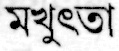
মখুৎতা
